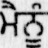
ਮੈਨੂੰ
